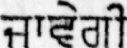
ਜਾਵੇਗੀ
